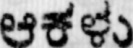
ಆಕಳು
